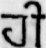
ਹੀ
